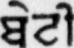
ਬੇਟੀ
